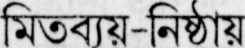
মিতব্যয়-নিষ্ঠায়
